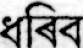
ধৰিব
